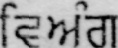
ਵਿਅੰਗ
